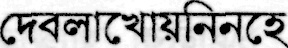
দেবলাখোয়নিনহে
